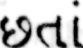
છતાં
